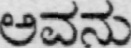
ಅವನು
